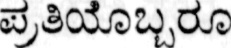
ಪ್ರತಿಯೊಬ್ಬರೂ
